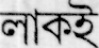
লাকই
